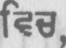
ਵਿਚ,
